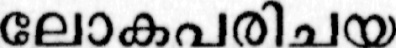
ലോകപരിചയ
